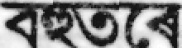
বহুতৰে
